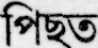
পিছত
